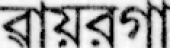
ৱায়রগা
